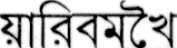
য়ারিবমখৈ
